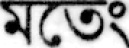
মতেং
